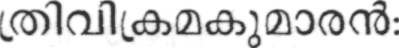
ത്രിവിക്രമകുമാരന്‍:
